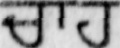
ਚਾਹ
